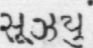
સુઝ્યું
